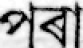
পৰা
